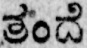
ತಂದೆ
